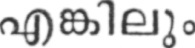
എങ്കിലും
